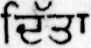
ਦਿੱਤਾ
